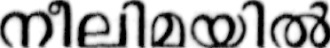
നീലിമയില്‍
